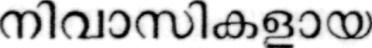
നിവാസികളായ
